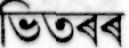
ভিতৰৰ
